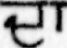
ਦਾ
